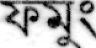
ফমুং
